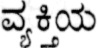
ವ್ಯಕ್ತಿಯ
